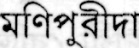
মণিপুরীদা
